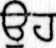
ਉਹ
